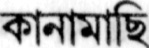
কানামাছি
